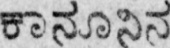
ಕಾನೂನಿನ
